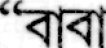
“বাবা
